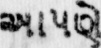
આપણે
